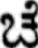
ಚೆ
